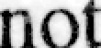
not
